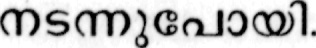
നടന്നുപോയി.
